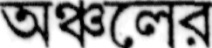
অঞ্চলের
